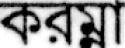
করম্না
